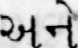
અને
